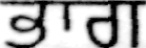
ਭਾਗ
